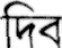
দিব
